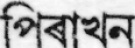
পিৰাখন
